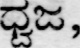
ಧ್ವಜ,
